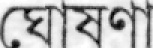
ঘোষণা
